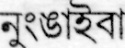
নুংঙাইবা
